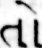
તો
